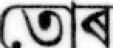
তোৰ
